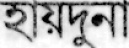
হায়দুনা
